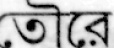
তৌরে
